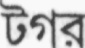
টগর
